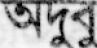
অদুবু
